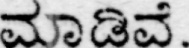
ಮಾಡಿವೆ.
